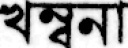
খম্বনা
